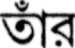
তাঁর
